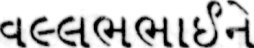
વલ્લભભાઈને
